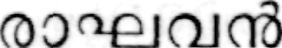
രാഘവന്‍
